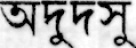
অদুদসু
